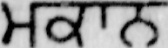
ਮਕਾਨ
